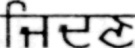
ਜਿਦਣ
